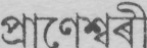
প্ৰাণেশ্বৰী
